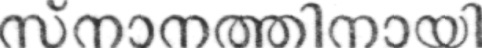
സ്നാനത്തിനായി
